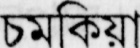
চমকিয়া
